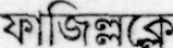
ফাজিল্লক্লে
